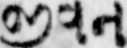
જીવન
